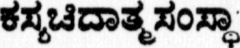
ಕಸ್ಯಚಿದಾತ್ಮಸಂಸ್ಥಾ
